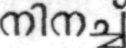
നിനച്ച്
